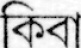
কিবা
